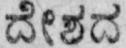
ದೇಶದ
